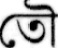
তৌ
